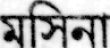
মসিনা
